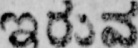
ಇರುವ
